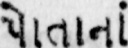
પોતાનાં
